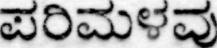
ಪರಿಮಳವು
